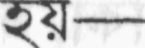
হয়–
